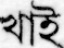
খাই
